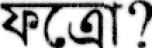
ফত্রো?
